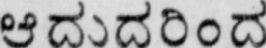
ಆದುದರಿಂದ
